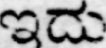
ಇದು
